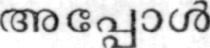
അപ്പോള്‍
